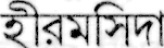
হীরমসিদা
